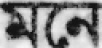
মনে
